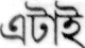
এটাই
